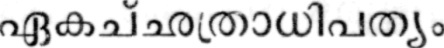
ഏകച്ഛത്രാധിപത്യം
